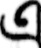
এ
